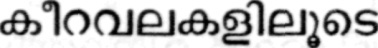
കീറവലകളിലൂടെ
